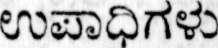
ಉಪಾಧಿಗಳು
